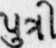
પુત્રી
